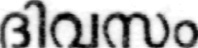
ദിവസം
